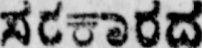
ಸರಕಾರದ
